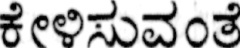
ಕೇಳಿಸುವಂತೆ
